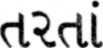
તરતાં
